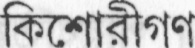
কিশোরীগণ
